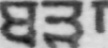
ਬੜਾ
